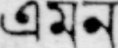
এমন
